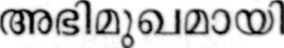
അഭിമുഖമായി
